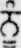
ਨੂੰ
